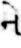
ને
